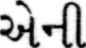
એની
